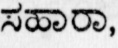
ಸಹಾರಾ,
